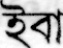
ইবা
